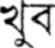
খুব
